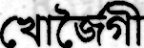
খোর্জৈগী
